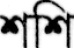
শশি
